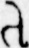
તે
